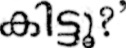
കിട്ടൂ?'
